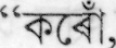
"কৰোঁ,
